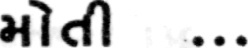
મોતી...........
